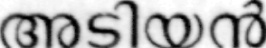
അടിയന്‍
